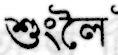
শুংলৈ
